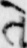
તે
